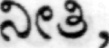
ನೀತಿ,
